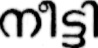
നീട്ടി
